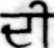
ਦੀ
